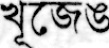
খূজেঙ়
